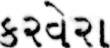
કરવેરા
